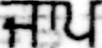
ਜਾਪ
